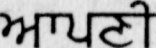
ਆਪਣੀ
